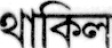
থাকিল
